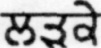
ਲੜਕੇ
